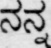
ನನ್ನ
